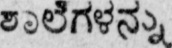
ಶಾಲೆಗಳನ್ನು
